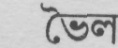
ভৈল
